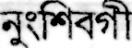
নুংশিবগী
